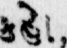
કહો,
